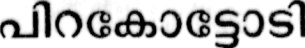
പിറകോട്ടോടി
